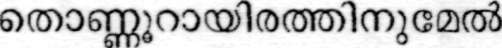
തൊണ്ണൂറായിരത്തിനുമേല്‍
